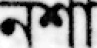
নশা
